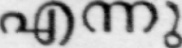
എന്നു
